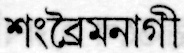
শংব্রৈমনাগী
